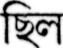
ছিল
